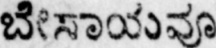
ಬೇಸಾಯವೂ
